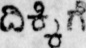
ದಿಕ್ಕಿಗೆ
